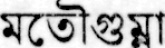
মতৌগুম্না
